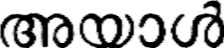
അയാള്‍
